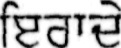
ਇਰਾਦੇ
